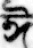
ঈ
